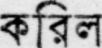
করিল
